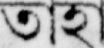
তাহা
